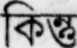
কিন্তু
